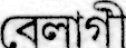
বেলাগী
